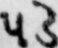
પડે
